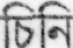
চিনি
